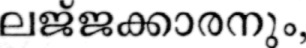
ലജ്ജക്കാരനും,
